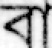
বা
